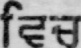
ਵਿਚ
